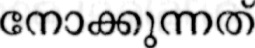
നോക്കുന്നത്
